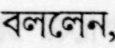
বললেন,
